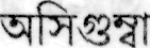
অসিগুম্বা
